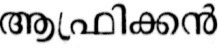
ആഫ്രിക്കന്‍
